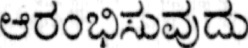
ಆರಂಭಿಸುವುದು
